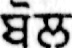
ਬੋਲ
